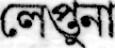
লেপ্তুনা
